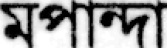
মপান্দা
